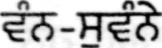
ਵੰਨ-ਸੁਵੰਨੇ
